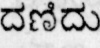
ದಣಿದು
